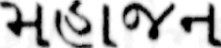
મહાજન
